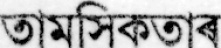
তামসিকতাৰ
